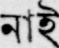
নাই
